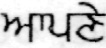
ਆਪਣੇ
